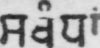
ਸਬੰਧਾਂ
